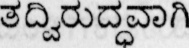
ತದ್ವಿರುದ್ಧವಾಗಿ
